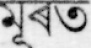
মূৰত
